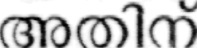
അതിന്
